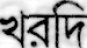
খরদি
